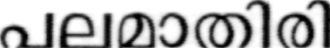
പലമാതിരി
